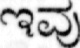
ಇವು
